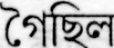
গৈছিল
